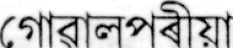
গোৱালপৰীয়া
